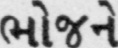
ભોજને
